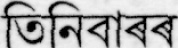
তিনিবাৰৰ
